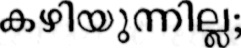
കഴിയുന്നില്ല;
